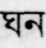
ঘন
